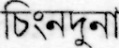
চিংনদুনা
